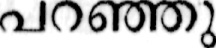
പറഞ്ഞു
